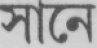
সানে
